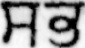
ਸਭ
